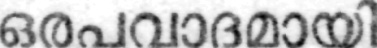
ഒരപവാദമായി
